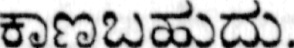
ಕಾಣಬಹುದು.
